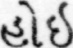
હોઈ
